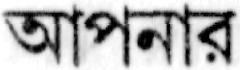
আপনার
